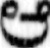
ಆ
